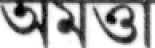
অমত্তা
